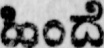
ಹಿಂದೆ
